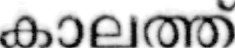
കാലത്ത്
